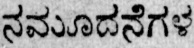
ನಮೂದನೆಗಳ
